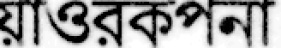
য়াওরকপনা
